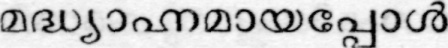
മദ്ധ്യാഹ്നമായപ്പോള്‍
